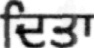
ਦਿਤਾ
